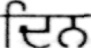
ਦਿਨ
